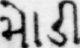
મોડી
